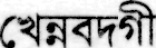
খেন্নবদগী
